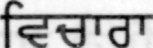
ਵਿਚਾਰਾ
